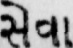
સેવા
